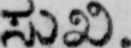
ಸುಖಿ.
